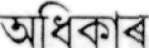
অধিকাৰ
